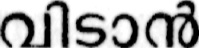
വിടാന്‍
